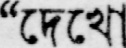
‘‘দেখো
